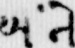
બંને
